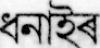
ধনাইৰ
